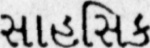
સાહસિક
